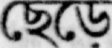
ছেড়ে
